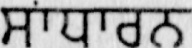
ਸਾਧਾਰਨ
